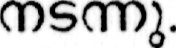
നടന്നു.
